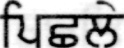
ਪਿਛਲੇ
